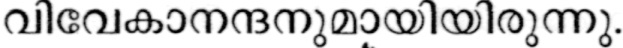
വിവേകാനന്ദനുമായിയിരുന്നു.
